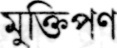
মুক্তিপণ
